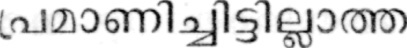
പ്രമാണിച്ചിട്ടില്ലാത്ത
